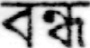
বন্ধ
